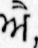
ਐ,
